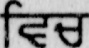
ਵਿਚ
